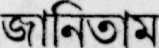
জানিতাম
